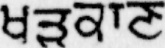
ਖੜਕਾਣ
